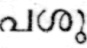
പശു
